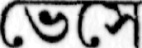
ভেসে
